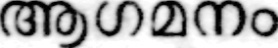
ആഗമനം
